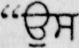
''ਉਸ
